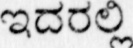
ಇದರಲ್ಲಿ
